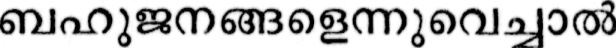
ബഹുജനങ്ങളെന്നുവെച്ചാല്‍
